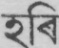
হৰি
